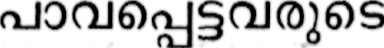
പാവപ്പെട്ടവരുടെ
